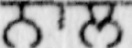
ਨਾਲ
